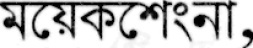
ময়েকশেংনা,
